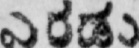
ಎರಡು
